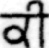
ਕੀ
